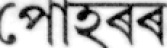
পোহৰৰ
